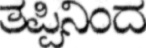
ತಪ್ಪಿನಿಂದ
